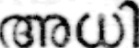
അധി
